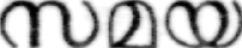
സമയ
